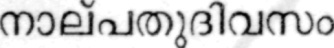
നാല്പതുദിവസം
